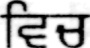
ਵਿਚ
